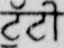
ਟੁੱਟੀ
